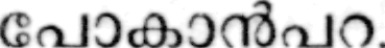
പോകാന്‍പറ.
